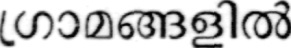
ഗ്രാമങ്ങളില്‍
